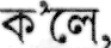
ক'লে,
